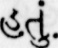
હતું.
